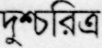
দুশ্চরিত্র
